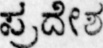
ಪ್ರದೇಶ
